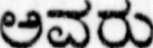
ಅವರು
